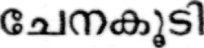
ചേനകൂടി
